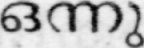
ഒന്നു
